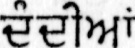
ਦੰਦੀਆਂ
